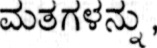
ಮತಗಳನ್ನು,
